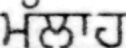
ਮੱਲਾਹ
